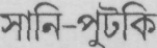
সানি-পুটকি
